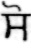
ਸੋ
